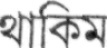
থাকিম
